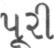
પૂરી
